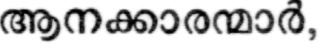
ആനക്കാരന്മാര്‍,
